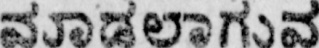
ಮಾಡಲಾಗುವ
